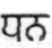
ਧਨ
